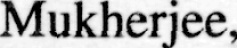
Mukherjee,
